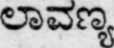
ಲಾವಣ್ಯ
